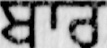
ਬਾਰ
